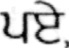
ਪਏ,
